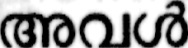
അവള്‍
